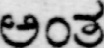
ಅಂತ
